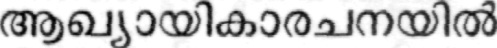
ആഖ്യായികാരചനയില്‍
